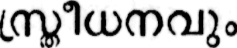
സ്ത്രീധനവും
